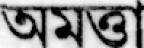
অমত্তা
